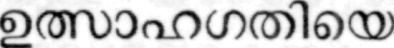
ഉത്സാഹഗതിയെ
